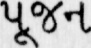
પૂજન
